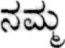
ನಮ್ಮ
